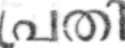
പ്രതി
